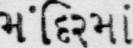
મંદિરમાં
